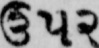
ઉપર
